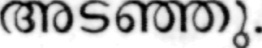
അടഞ്ഞു.
